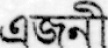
এজনী
